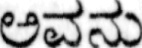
ಅವನು
